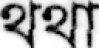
থথা
